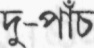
দু-পাঁচ
